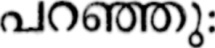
പറഞ്ഞു:
